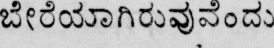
ಬೇರೆಯಾಗಿರುವುವೆಂದು
